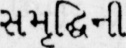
સમૃદ્ધિની
